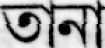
তানা
